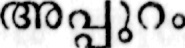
അപ്പുറം
